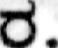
ರ.
